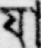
যা
